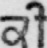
ਕੀ
